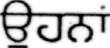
ਉਹਨਾਂ
